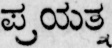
ಪ್ರಯತ್ನ
